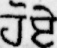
ਹੋਏ
